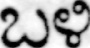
ಬಳಿ
